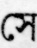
সে
